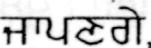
ਜਾਪਣਗੇ,
